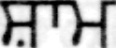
ਸ਼ਾਮ
